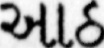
આઠ
